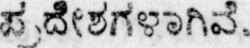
ಪ್ರದೇಶಗಳಾಗಿವೆ.
